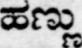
ಹಣ್ಣು
